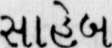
સાહેબ
